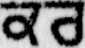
ਕਰ
